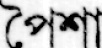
পৈশা
